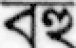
বহু
